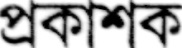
প্রকাশক
